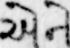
એને
